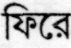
ফিরে
